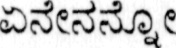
ಏನೇನನ್ನೋ
